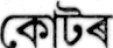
কোটৰ
